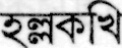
হল্লকখি
